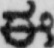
ಈ
